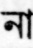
না
